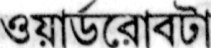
ওয়ার্ডরোবটা
